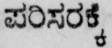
ಪರಿಸರಕ್ಕೆ
